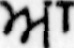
ਆ
